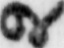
જ
